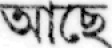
আছে
